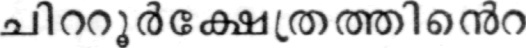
ചിററൂര്‍ക്ഷേത്രത്തിന്റെ
